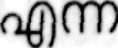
എന്ന
